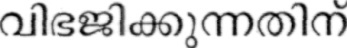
വിഭജിക്കുന്നതിന്
